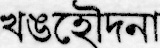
খঙহৌদনা
